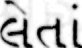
લેતાં
